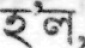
হ'ল,
